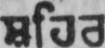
ਸ਼ਹਿਰ
